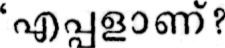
‘എപ്പളാണ്?
